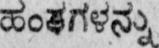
ಹಂತಗಳನ್ನು
